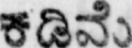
ಕಡಿಮೆ
